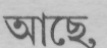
আছে,
